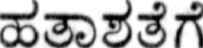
ಹತಾಶತೆಗೆ
